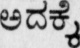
ಅದಕ್ಕೆ
